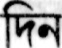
দিন
